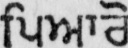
ਪਿਆਰੋ
